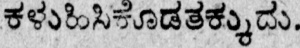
ಕಳುಹಿಸಿಕೊಡತಕ್ಕುದು.
